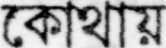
কোথায়
